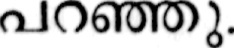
പറഞ്ഞു.
